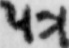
પત્ર
